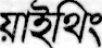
য়াইথিং
